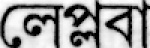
লেপ্লবা
